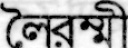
লৈরম্মী
